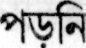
পড়নি
